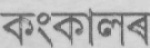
কংকালৰ
